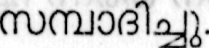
സമ്പാദിച്ചു.
